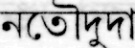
নতৌদুদা
